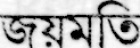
জয়মতি
